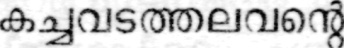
കച്ചവടത്തലവന്റെ
